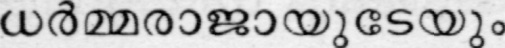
ധര്‍മ്മരാജായുടേയും
